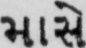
માસે
